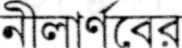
নীলার্ণবের
